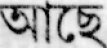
আছে
